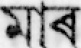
মাৰ
